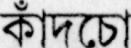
কাঁদচো
